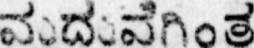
ಮದುವೆಗಿಂತ
